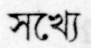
সখ্যে
